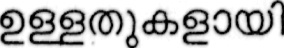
ഉള്ളതുകളായി
